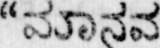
“ಮಾನವ
